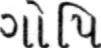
ગોપિ
